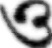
ও
